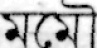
মমৌ
